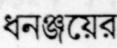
ধনঞ্জয়ের
